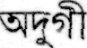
অদুগী
